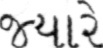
જ્યારે
